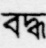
বদ্ধ
